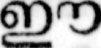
ഈ
